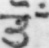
ਤੋਂ
